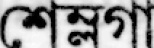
শেম্লগা
